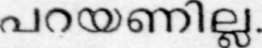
പറയണില്ല.
